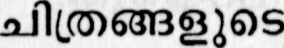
ചിത്രങ്ങളുടെ
